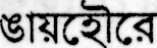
ঙায়হৌরে
